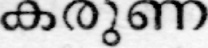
കരുണ
